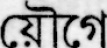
য়ৌগে
